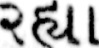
રહ્યા
